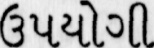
ઉપયોગી
